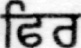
ਫਿਰ
